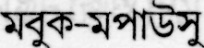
মবুক-মপাউসু
